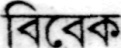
বিবেক
